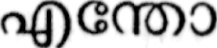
എന്തോ
